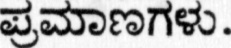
ಪ್ರಮಾಣಗಳು.
